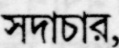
সদাচার,
